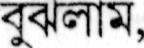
বুঝলাম,
